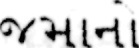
જમાનો
